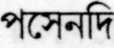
পসেনদি
